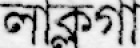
লাক্লগা
